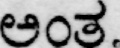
ಅಂತ.
